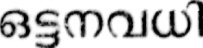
ഒട്ടനവധി
